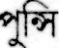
পুন্সি
